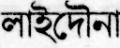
লাইদৌনা
